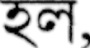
হল,
